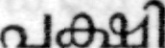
പക്ഷി
